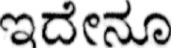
ಇದೇನೂ
